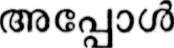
അപ്പോള്‍
